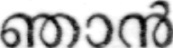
ഞാന്‍
